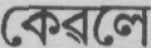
কেৱলে
